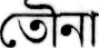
তৌনা
